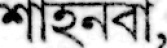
শাহনবা,
